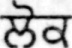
ਲੋਕ
